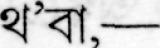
থ'বা,-
